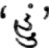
'હું'
